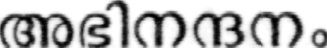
അഭിനന്ദനം
